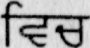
ਵਿਚ
